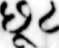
છૂટ
